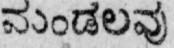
ಮಂಡಲವು
